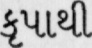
કૃપાથી
